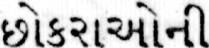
છોકરાઓની
